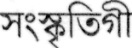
সংস্কৃতিগী
